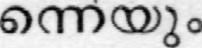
ന്നെയും
